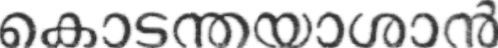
കൊടന്തയാശാന്‍
